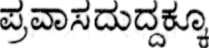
ಪ್ರವಾಸದುದ್ದಕ್ಕೂ
